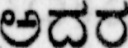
ಅದರ
